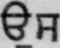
ਉਸ
